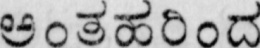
ಅಂತಹರಿಂದ
